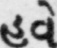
હવે
